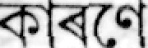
কাৰণে
